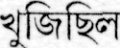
খুজিছিল
